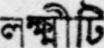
লক্ষ্মীটি
